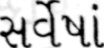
સર્વેષાં
